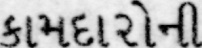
કામદારોની
